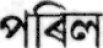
পৰিল
